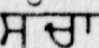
ਸੱਚਾ
